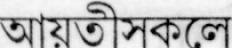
আয়তীসকলে
